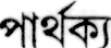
পার্থক্য
